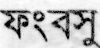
ফংবসু
